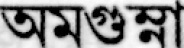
অমগুম্না
